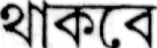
থাকবে
